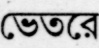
ভেতরে
